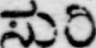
ಸುರಿ
